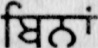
ਬਿਨਾਂ
